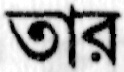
তার
